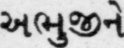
અભુજીને
